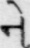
ને
